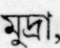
মুদ্রা,
